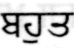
ਬਹੁਤ
